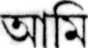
আমি
